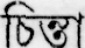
চিন্তা
